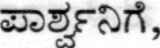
ಪಾರ್ಶ್ವನಿಗೆ,
